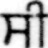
ਸੀ
